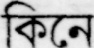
কিনে
